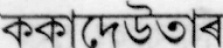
ককাদেউতাৰ
